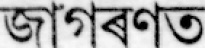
জাগৰণত
